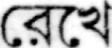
রেখে
